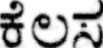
ಕೆಲಸ
